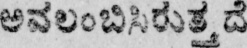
ಅವಲಂಬಿಸಿರುತ್ತದೆ
